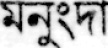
মনুংদা
